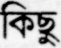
কিছু
